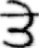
ਤੇ
